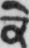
ਕੇ
